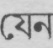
যেন
